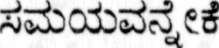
ಸಮಯವನ್ನೇಕೆ
